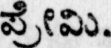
ಪ್ರೇಮಿ.
